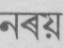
নৰয়
